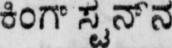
ಕಿಂಗ್‌ಸ್ಟನ್‌ನ
